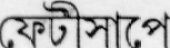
ফেটীসাপে
